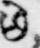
છે,
